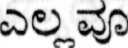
ಎಲ್ಲವೂ
